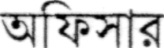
অফিসার
